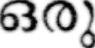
ഒരു
